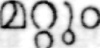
മറ്റും
